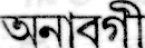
অনাবগী
